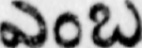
ಎಂಬ
